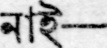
নাই—
